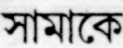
সামাকে
